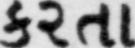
કરતા
